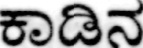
ಕಾಡಿನ
